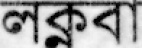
লক্নবা
